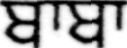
ਬਾਬਾ
